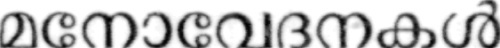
മനോവേദനകള്‍
